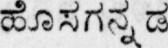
ಹೊಸಗನ್ನಡ
